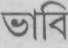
ভাবি
